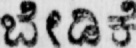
ಬೇಡಿಕೆ
